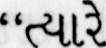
"ત્યારે
